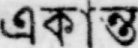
একান্ত
